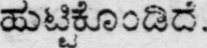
ಹುಟ್ಟಿಕೊಂಡಿದೆ.
